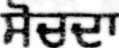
ਸੋਚਦਾ
